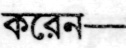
করেন–
